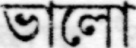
ভালো
